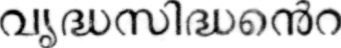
വൃദ്ധസിദ്ധന്റെ
